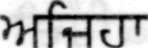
ਅਜਿਹਾ
